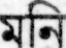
মনি
